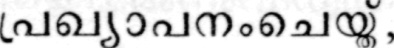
പ്രഖ്യാപനംചെയ്ത്,
